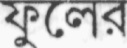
ফুলের
